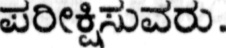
ಪರೀಕ್ಷಿಸುವರು.
